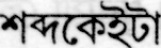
শব্দকেইটা
